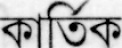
কার্তিক
